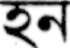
হন
